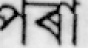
পৰা
